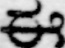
ಈ
